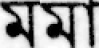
মমা
